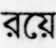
রয়ে
